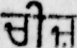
ਚੀਜ਼
